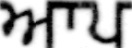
ਆਪ
